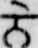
ਨੇ
